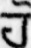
ਹੋ
